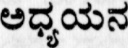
ಅಧ್ಯಯನ
